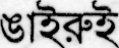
ঙাইরুই
